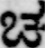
ಚ
